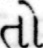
તો
